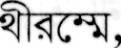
থীরম্মে,
